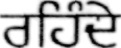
ਰਹਿੰਦੇ
